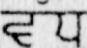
ਵੱਧ
